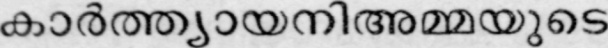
കാര്‍ത്ത്യായനിഅമ്മയുടെ
